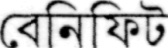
বেনিফিট
